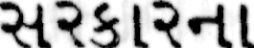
સરકારના
